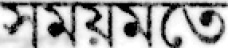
সময়মতে
